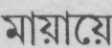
মায়ায়ে
